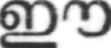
ഈ
